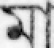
মা
